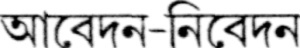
আবেদন-নিবেদন
